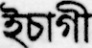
ইচাগী
